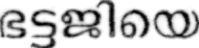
ഭട്ടജിയെ
